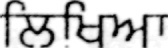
ਲਿਖਿਆ
